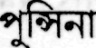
পুন্সিনা
